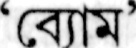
‘ব্যোম’
